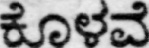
ಕೊಳವೆ
